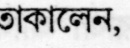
তাকালেন,
